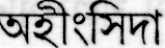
অহীংসিদা
